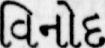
વિનોદ
